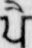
ਪੈ
